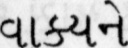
વાક્યને
